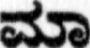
ಮಾ
